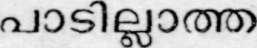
പാടില്ലാത്ത
